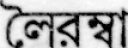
লৈরম্বা
